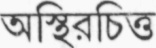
অস্থিরচিত্ত
